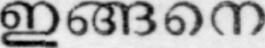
ഇങ്ങനെ
